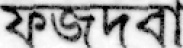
ফজদবা
